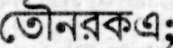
তৌনরকএ;
